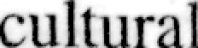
cultural
